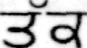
ਤੱਕ
